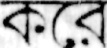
করে
